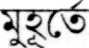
মুহূর্তে
